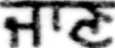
ਜਾਣ
